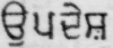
ਉਪਦੇਸ਼
